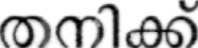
തനിക്ക്
